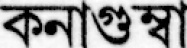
কনাগুম্বা
